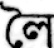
লৈ
